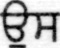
ਉਸ
